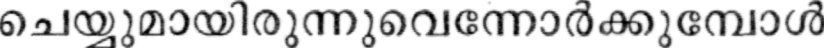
ചെയ്യുമായിരുന്നുവെന്നോര്‍ക്കുമ്പോള്‍
